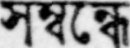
সম্বন্ধে
